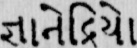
જ્ઞાનેદ્રિયો
